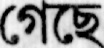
গেছে
